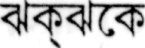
ঝক্ঝকে
